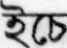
ইচে
